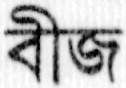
বীজ
